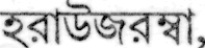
হরাউজরম্বা,
